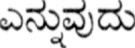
ಎನ್ನುವುದು
